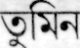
তুমিন
